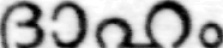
ദാഹം
